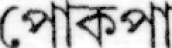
পোকপা
